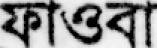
ফাওবা
